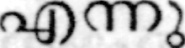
എന്നു
